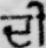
ਦੀ
